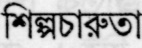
শিল্পচারুতা
